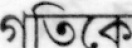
গতিকে
